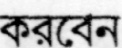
করবেন
